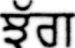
ਝੱਗ
